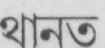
থানত
